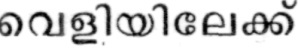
വെളിയിലേക്ക്
